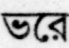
ভরে
